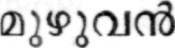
മുഴുവന്‍
